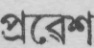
প্ৰৱেশ
